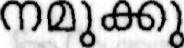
നമുക്കു
